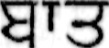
ਬਾਤ
